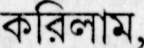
করিলাম,
